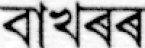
বাখৰৰ
